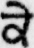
ਕੇ
